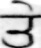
ਤੇ
